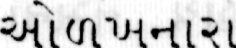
ઓળખનારા
